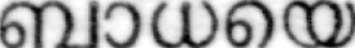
ബാധയെ
